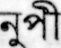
নুপী
